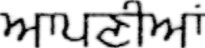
ਆਪਣੀਆਂ
